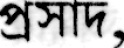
প্রসাদ,
